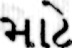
માટે
